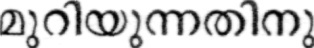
മുറിയുന്നതിനു
